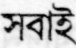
সবাই
